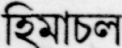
হিমাচল
